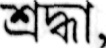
শ্রদ্ধা,
